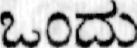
ಒಂದು
